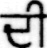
ਦੀ
